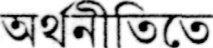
অর্থনীতিতে
